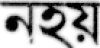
নহয়
